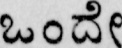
ಒಂದೇ
